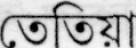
তেতিয়া
